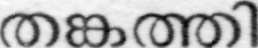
തങ്കത്തി
